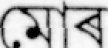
মোৰ
